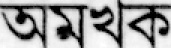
অমখক
